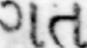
ગત
